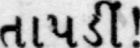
તાપડીં!
